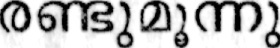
രണ്ടുമൂന്നു
